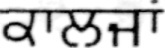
ਕਾਲਜਾਂ
